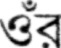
ওঁর
